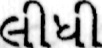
લીધી
